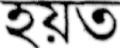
হয়ত
